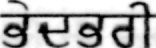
ਭੇਦਭਰੀ
